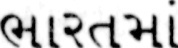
ભારતમાં
